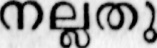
നല്ലതു
